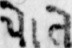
પોતે
